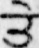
ਤੇ
